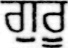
ਗੁਰੂ
